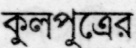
কুলপুত্রের
